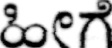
ಹೀಗೆ
